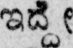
ಇದ್ದೇ
